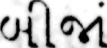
બીજાં
